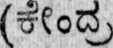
(ಕೇಂದ್ರ
